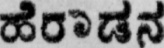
ಹೆರಾಡನ
